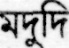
মদুদি
